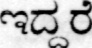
ಇದ್ದರೆ
